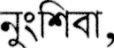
নুংশিবা,
